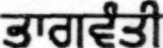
ਭਾਗਵੰਤੀ
